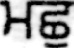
ਮਛੁ
